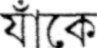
যাঁকে
